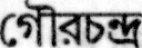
গৌরচন্দ্র
